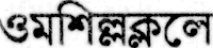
ওমশিল্লক্ললে
